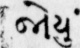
જોયું
